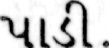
પાડી.
